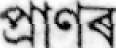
প্রাণৰ
